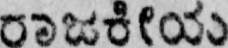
ರಾಜಕೀಯ
